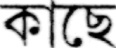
কাছে
